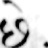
છે.
